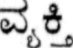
ವ್ಯಕ್ತಿ
